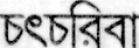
চৎচরিবা
